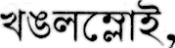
খঙলম্লোই,
